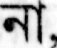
না,
